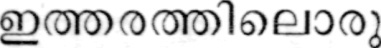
ഇത്തരത്തിലൊരു
